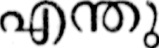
എന്തു
